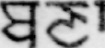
ਬਣਾ
